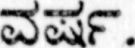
ವರ್ಷ.
